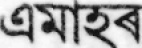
এমাহৰ
